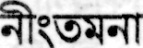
নীংতমনা
